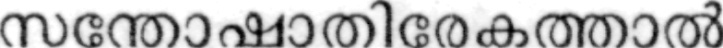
സന്തോഷാതിരേകത്താല്‍
